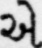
એ
